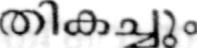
തികച്ചും
